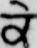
ਕੇ
